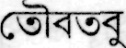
তৌবতবু
